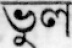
ভুল
